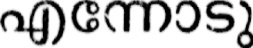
എന്നോടു
